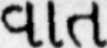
વાત
